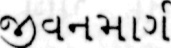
જીવનમાર્ગ
